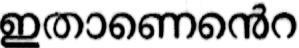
ഇതാണെന്റെ
